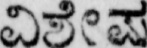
ವಿಶೇಷ
